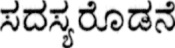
ಸದಸ್ಯರೊಡನೆ
